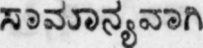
ಸಾಮಾನ್ಯವಾಗಿ
